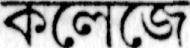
কলেজে
